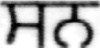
ਸਨ
